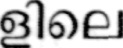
ളിലെ
